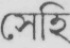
সেহি
